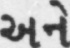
અને
